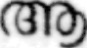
ആ
